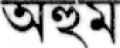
অহুম
